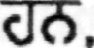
ਹਨ,
